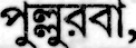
পুল্লুরবা,
